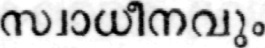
സ്വാധീനവും
